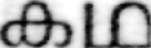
കഥ
